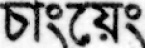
“ঐ
